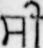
ਸੀ
